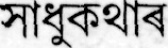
সাধুকথাৰ
